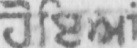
ਹੋਇਆਂ
